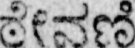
ಠೇವಣಿ
